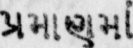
પ્રમાણમાં
